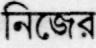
নিজের
